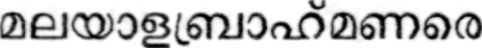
മലയാളബ്രാഹ്മണരെ
